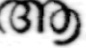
ആ
